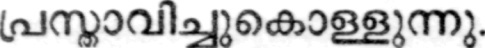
പ്രസ്താവിച്ചുകൊള്ളുന്നു.
